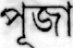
পূজা
